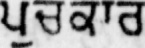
ਪੁਚਕਾਰ
